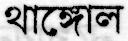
থাঙ্গোল
